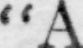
"A
